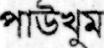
পাউখুম
